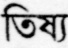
তিষ্য
